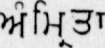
ਅੰਮ੍ਰਿਤਾ
